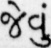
જેવું
